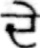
ਦੇ
